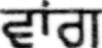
ਵਾਂਗ
